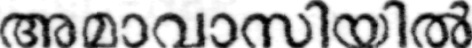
അമാവാസിയില്‍
